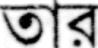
তার
